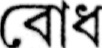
বোধ
